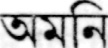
অমনি
